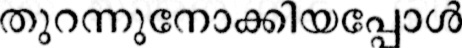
തുറന്നുനോക്കിയപ്പോള്‍
